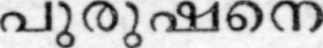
പുരുഷനെ
